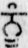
ਨੂੰ
